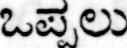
ಒಪ್ಪಲು
